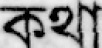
কথা
